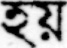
হয়
